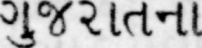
ગુજરાતના
